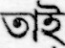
তাই
